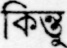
কিন্তু
